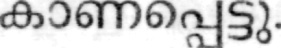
കാണപ്പെട്ടു.
